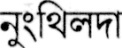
নুংথিলদা
